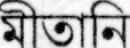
মীতানি
